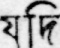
যদি
